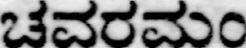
ಚವರಮಂ
